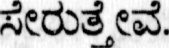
ಸೇರುತ್ತೇವೆ.
